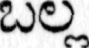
ಬಲ್ಲ
